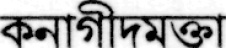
কনাগীদমক্তা
